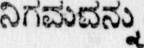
ನಿಗಮವನ್ನು
